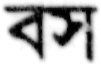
বস
